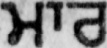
ਮਾਰ
